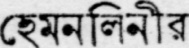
হেমনলিনীর
